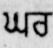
ਘਰ
